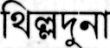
থিল্লদুনা
